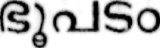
ഭൂപടം
